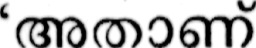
‘അതാണ്
